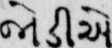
જોડીએ
